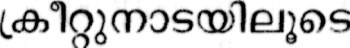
ക്രീറ്റുനാടയിലൂടെ
